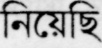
নিয়েছি
